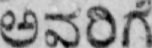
ಅವರಿಗೆ
